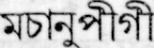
মচানুপীগী
